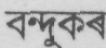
বন্দুকৰ
